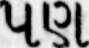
પણ
